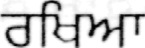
ਰਖਿਆ
